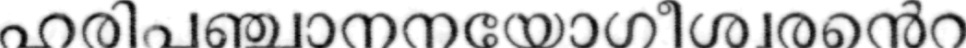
ഹരിപഞ്ചാനനയോഗീശ്വരന്റെ
